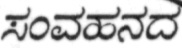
ಸಂವಹನದ
